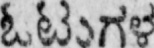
ಓಟುಗಳ
